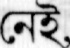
নেই,
